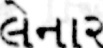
લેનાર
